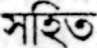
সহিত
